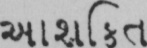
આશક્તિ
